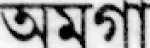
অমগা
